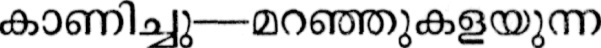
കാണിച്ചു-മറഞ്ഞുകളയുന്ന
